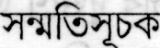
সন্মতিসূচক
